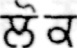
ਲੋਕ
